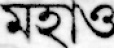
মহাও
